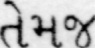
તેમજ
